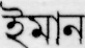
ইমান
